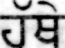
ਹੱਥੇ
